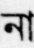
না
